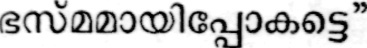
ഭസ്മമായിപ്പോകട്ടെ”
